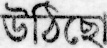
উঠিছো
